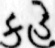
કહે
